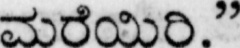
ಮರೆಯಿರಿ."
